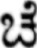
ಚೆ
